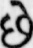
છે
